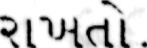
રાખતો.
